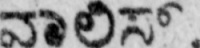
ವಾಲಿಸ್.
